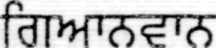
ਗਿਆਨਵਾਨ
